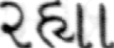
રહ્યા
